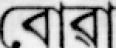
বোৱা
